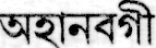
অহানবগী
